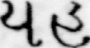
યહ
